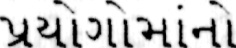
પ્રયોગોમાંનો
